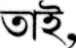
তাই,
